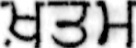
ਖ਼ਤਮ
